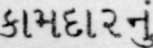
કામદારનું
